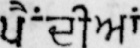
ਪੈਂਦੀਆਂ
